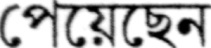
পেয়েছেন
